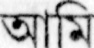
আমি
